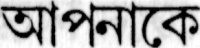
আপনাকে
